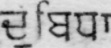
ਦੁਬਿਧਾ
